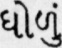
ધોળું
